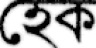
হেক
